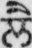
ਲੈ
